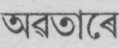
অৱতাৰে
